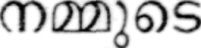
നമ്മുടെ
